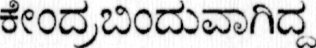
ಕೇಂದ್ರಬಿಂದುವಾಗಿದ್ದ
